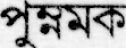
পুম্নমক
